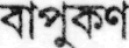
বাপুকণ
